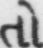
તો
